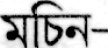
মচিন-
